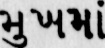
મુખમાં
